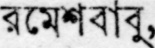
রমেশবাবু,
